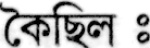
কৈছিলঃ
